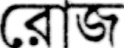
রোজ
